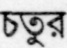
চতুর
